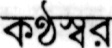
কণ্ঠস্বর
